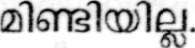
മിണ്ടിയില്ല.
